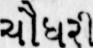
ચૌધરી
